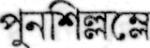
পুনশিল্লম্লে
